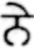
ਨੇ
